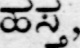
ಹಸ್ತ,
